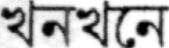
খনখনে
